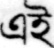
এই
